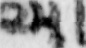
આ
